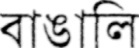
বাঙালি
